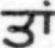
ਤਾਂ
